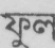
ফুল
